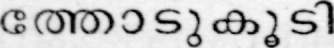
ത്തോടുകൂടി
